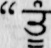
''ਤੂੰ
